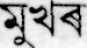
মুখৰ
